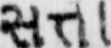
સત્તા
